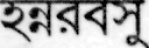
হন্নরবসু
